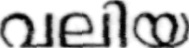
വലിയ
